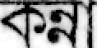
কন্না
